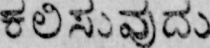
ಕಲಿಸುವುದು
